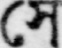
সে
